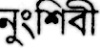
নুংশিবী
